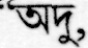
“অদু,
